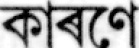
কাৰণে
